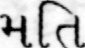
મતિ
